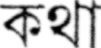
কথা
